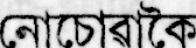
নোচোৱাকৈ
